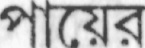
পায়ের
